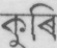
কুৰি
